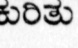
ಕುರಿತು
